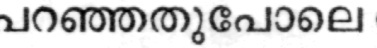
പറഞ്ഞതുപോലെ
